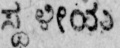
ಸ್ಥಳೀಯ
